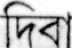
দিবা
